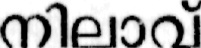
നിലാവ്
